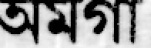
অমগা
